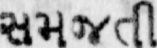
સમજતી
